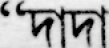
"দাদা
